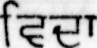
ਵਿਦਾ
